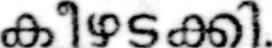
കീഴടക്കി.
